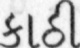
કાઠી
